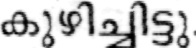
കുഴിച്ചിട്ടു.
